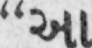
"આ
